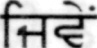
ਜਿਵੇਂ
